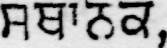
ਸਥਾਨਕ,
